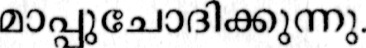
മാപ്പുചോദിക്കുന്നു.
